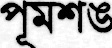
পূমশঙ
